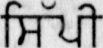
ਸਿੱਪੀ
